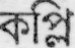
কপ্লি
